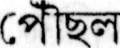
পৌঁছল
